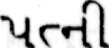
પત્ની
